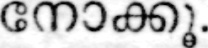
നോക്കൂ.
